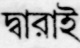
দ্বারাই
